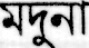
মদুনা
